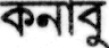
কনাবু
